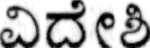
ವಿದೇಶಿ
